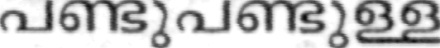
പണ്ടുപണ്ടുള്ള
